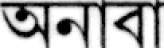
অনাবা
